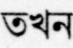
তখন
